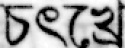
চৎখ্রে
